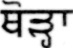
ਥੋੜ੍ਹਾ
